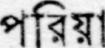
পরিয়া
